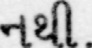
નથી.
